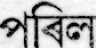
পৰিল
